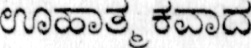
ಊಹಾತ್ಮಕವಾದ
